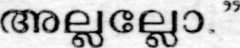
അല്ലല്ലോ.''
